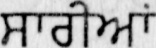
ਸਾਰੀਆਂ
